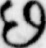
છ
